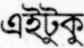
এইটুকু
